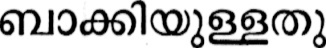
ബാക്കിയുള്ളതു
